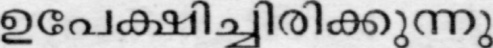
ഉപേക്ഷിച്ചിരിക്കുന്നു
